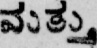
ಮತ್ತು
